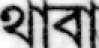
থাবা
